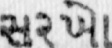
સરખો
